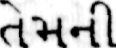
તેમની
